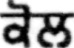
ਕੋਲ
